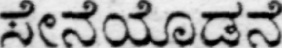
ಸೇನೆಯೊಡನೆ
